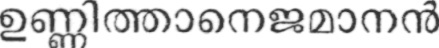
ഉണ്ണിത്താനെജമാനന്‍
